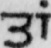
ਤਾਂ
